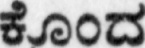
ಕೊಂದ
